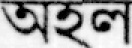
অহল
